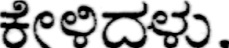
ಕೇಳಿದಳು.
